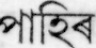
পাহিৰ
